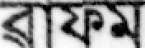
ৱাফম
